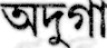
অদুগা
